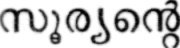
സൂര്യന്റെ
